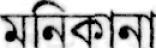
মনিকানা
